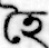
হৈ
